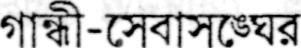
গান্ধী-সেবাসঙ্ঘের
